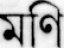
মণি
